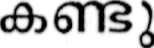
കണ്ടു
